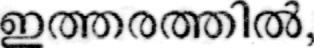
ഇത്തരത്തില്‍,
